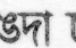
ঙদা
